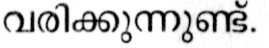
വരിക്കുന്നുണ്ട്.
